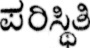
ಪರಿಸ್ಥಿತಿ
